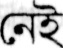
নেই
